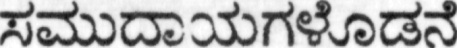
ಸಮುದಾಯಗಳೊಡನೆ
